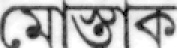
মোস্তাক
